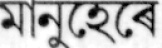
মানুহেৰে
